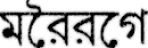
মরৈরগে
